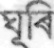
ঘূৰি
